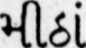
મીઠાં
